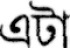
এটা
